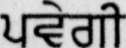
ਪਵੇਗੀ
